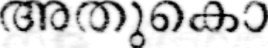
അതുകൊ
